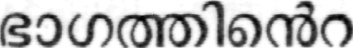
ഭാഗത്തിന്റെ
